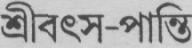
শ্ৰীবৎস-পান্তি
